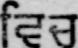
ਵਿਚ
